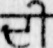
ਦੀ
